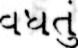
વધતું
